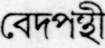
বেদপন্থী
